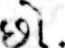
છો.
